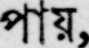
পায়,
